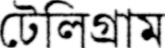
টেলিগ্রাম
